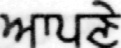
ਆਪਣੇ
